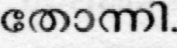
തോന്നി.
